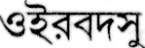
ওইরবদসু
